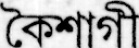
কৈশাগী
